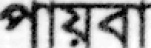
পায়বা
